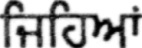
ਜਿਹਿਆਂ
